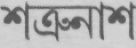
শত্ৰুনাশ
